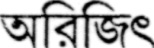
অরিজিৎ
